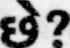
છે?
